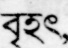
বৃহত্,
